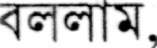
বললাম,
